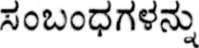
ಸಂಬಂಧಗಳನ್ನು
